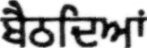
ਬੈਠਦਿਆਂ
